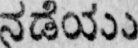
ನಡೆಯು
